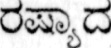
ರಷ್ಯಾದ
